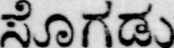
ಸೊಗಡು
